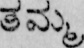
ತಮ್ಮ
